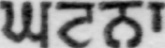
ਘਟਨਾ
